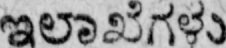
ಇಲಾಖೆಗಳು
